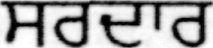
ਸਰਦਾਰ
